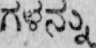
ಗಳನ್ನು
